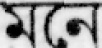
মনে
